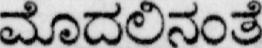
ಮೊದಲಿನಂತೆ
